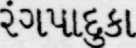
રંગપાદુકા
